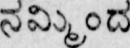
ನಮ್ಮಿಂದ
